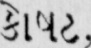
કોષટ,
